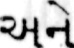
અને
